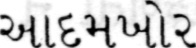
આદમખોર
